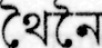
থৈনৈ
